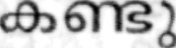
കണ്ടു
